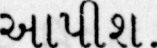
આપીશ.
